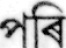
পৰি
